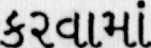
કરવામાં
